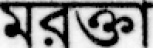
মরক্তা
